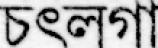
চৎলগা
